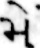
મેં
